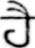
ਹੈ
